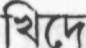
খিদে
